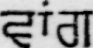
ਵਾਂਗ
